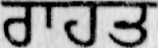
ਰਾਹਤ
